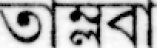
তাম্লবা
